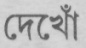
দেখোঁ
